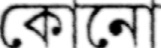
কোনো
